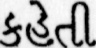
કહેતી
